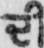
ਦੀ
